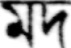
মদ
